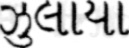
ઝુલાયા
